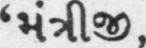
'મંત્રીજી,
